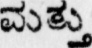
ಮತ್ತು
